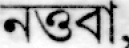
নত্তবা,
